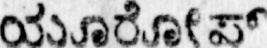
ಯೂರೋಪ್
